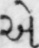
એ
